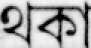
থকা
